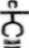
ਨੂੰ
